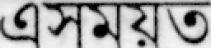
এসময়ত
